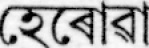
হেৰোৱা
